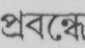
প্ৰবন্ধে
